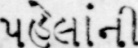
પહેલાંની
